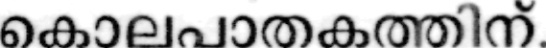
കൊലപാതകത്തിന്.
